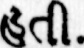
હતી.
